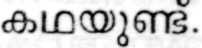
കഥയുണ്ട്.
